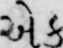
એક
